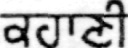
ਕਹਾਣੀ
